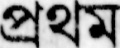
প্রথম
